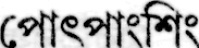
পোৎলমশিং
